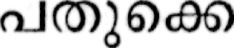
പതുക്കെ
